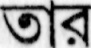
তার
